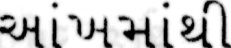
આંખમાંથી
